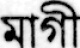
মাগী
